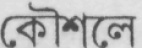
কৌশলে
